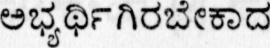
ಅಭ್ಯರ್ಥಿಗಿರಬೇಕಾದ
